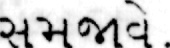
સમજાવે.
